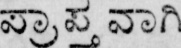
ಪ್ರಾಪ್ತವಾಗಿ
